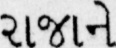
રાજાને
